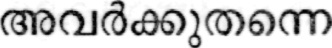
അവര്‍ക്കുതന്നെ
